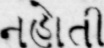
નહોતી
